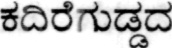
ಕದಿರೆಗುಡ್ಡದ
